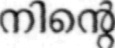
നിന്റെ
